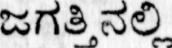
ಜಗತ್ತಿನಲ್ಲಿ
